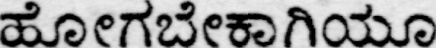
ಹೋಗಬೇಕಾಗಿಯೂ
